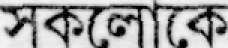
সকলোকে
